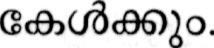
കേള്‍ക്കും.
